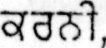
ਕਰਨੀ,
